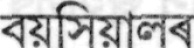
বয়সিয়ালৰ
